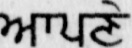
ਆਪਣੇ
